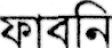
ফাবনি
